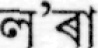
ল'ৰা
